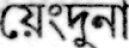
য়েংদুনা
